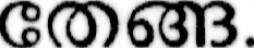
തേങ്ങ.
